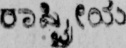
ರಾಷ್ಟ್ರೀಯ
